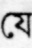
যে
